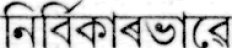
নির্বিকাৰভাৱে
